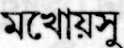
মখোয়সু
